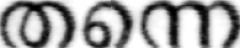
തന്നെ
